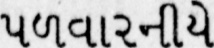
પળવારનીયે
